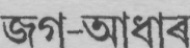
জগ-আধাৰ
